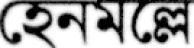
হেনমল্লে
